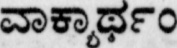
ವಾಕ್ಯಾರ್ಥಂ
